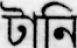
টানি
